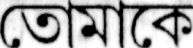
তোমাকে
